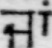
ਜਾਂ
